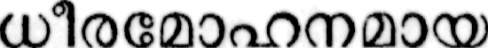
ധീരമോഹനമായ
